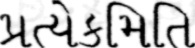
પ્રત્યેકમિતિ
